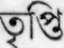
তৃপ্তি
